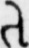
તે
